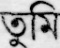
তুমি
